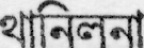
থানিলনা
